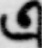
এ
